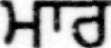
ਮਾਰ
